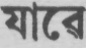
যাৱে
